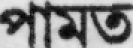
পামত
